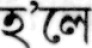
হ'লে
